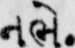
નભે.
